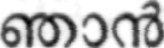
ഞാന്‍
